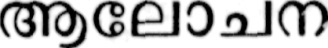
ആലോചന
